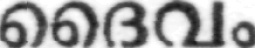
ദൈവം
